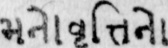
મનોવૃત્તિનો
